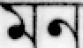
মন
